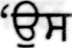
'ਉਸ
